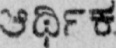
ಆರ್ಥಿಕ
